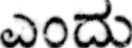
ಎಂದು
